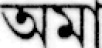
অমা
